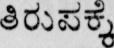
ತಿರುಪಕ್ಕೆ
